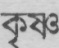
কৃষ্ণ
